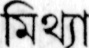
মিথ্যা
